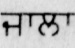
ਜਾਲਾ
